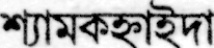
শ্যামকহ্ণাইদা
